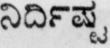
ನಿರ್ದಿಷ್ಟ
